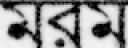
মরম
